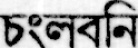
চংলবনি
